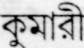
কুমারী
